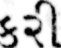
કરી
